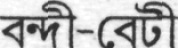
বন্দী-বেটী
